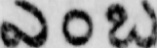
ಎಂಬ
